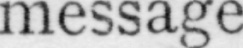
message
